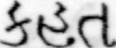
કહત
